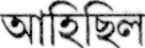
আহিছিল
